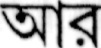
আর
